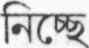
নিচ্ছে
